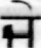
ਜੇ
